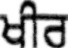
ਖੀਰ
